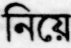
নিয়ে
